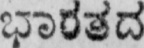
ಭಾರತದ
